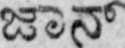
ಜಾನ್
